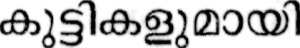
കുട്ടികളുമായി
